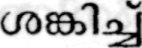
ശങ്കിച്ച്
